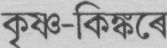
কৃষ্ণ-কিঙ্কৰে
